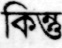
কিন্তু
